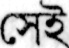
সেই
